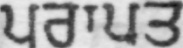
ਪਰਾਪਤ
